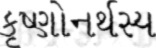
કૃષ્ણોનર્થસ્ય
